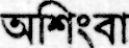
অশিংবা
